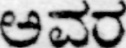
ಅವರ
